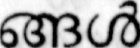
ങ്ങള്‍
